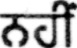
ਨਹੀਂ
